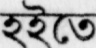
হইতে
